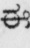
ಈ
